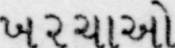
ખરચાઓ
